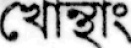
খোন্থাং
